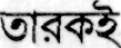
তারকই
